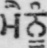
ਮੈਨੂੰ
